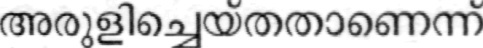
അരുളിച്ചെയ്തതാണെന്ന്
